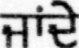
ਜਾਂਦੇ
